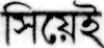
সিয়েই
